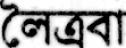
লৈত্রবা
